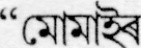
"মোমাইৰ
